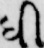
ઘી
